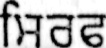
ਸਿਰਫ
